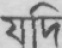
যদি
